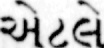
એટલે
